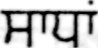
ਸਾਧਾਂ
